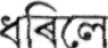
ধৰিলে
